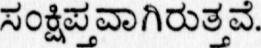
ಸಂಕ್ಷಿಪ್ತವಾಗಿರುತ್ತವೆ.
